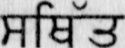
ਸਥਿੱਤ
